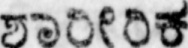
ಶಾರೀರಿಕ
